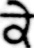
ਕੇ
